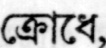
ক্রোধে,
